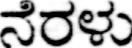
ನೆರಳು
